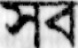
সব
